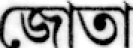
জোতা
